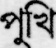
পুখি
